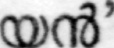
യന്‍'
